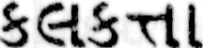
કલકત્તા
